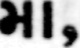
મા,
